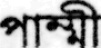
পাম্মী
